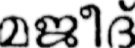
മജീദ്
